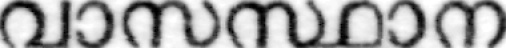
വാസസ്ഥാന
